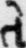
તે
